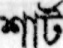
শার্ট
